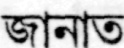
জানাত
